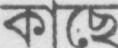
কাছে
